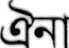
ঐনা
